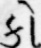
કો
